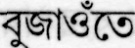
বুজাওঁতে
